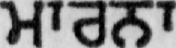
ਮਾਰਨਾ
